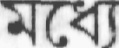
মধ্যে
